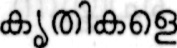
കൃതികളെ
